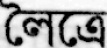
লৈত্রে
